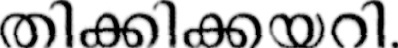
തിക്കിക്കയറി.
